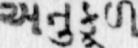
અનુકૂળ
